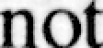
not
